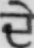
ਦੇ
